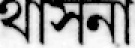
থাসনা
